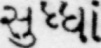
સુધ્ધાં
